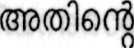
അതിന്റെ
